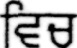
ਵਿਚ
